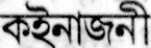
কইনাজনী
